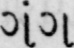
ગંગ
